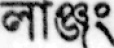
লাঞ্জং
